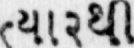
ત્યારથી
